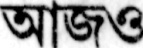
আজও
